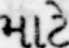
માટે
